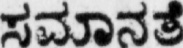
ಸಮಾನತೆ
